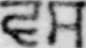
ਵਸ
